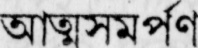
আত্মসমর্পণ
